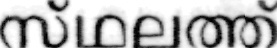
സ്ഥലത്ത്
